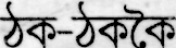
ঠক-ঠককৈ
